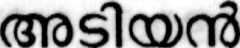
അടിയന്‍
